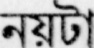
নয়টা
